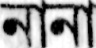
নানা
